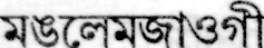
মঙলেমজাওগী
